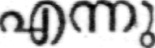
എന്നു
